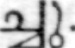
ച്ചു.
